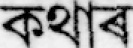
কথাৰ
